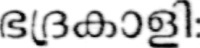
ഭദ്രകാളി:
